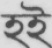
হই
